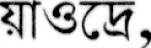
য়াওদ্রে,
